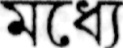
মধ্যে
